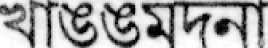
খাঙঙমদনা
